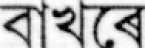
বাখৰে
